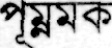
পূম্নমক
